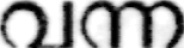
വന്ന
